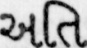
અતિ
